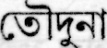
তৌদুনা
